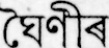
ঘৈণীৰ
